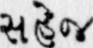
સહેજ
